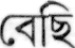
বেছি
